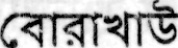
বোরাখাউ
